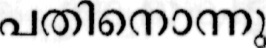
പതിനൊന്നു
